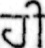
ਹੀ
